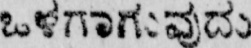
ಒಳಗಾಗುವುದು
